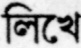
লিখে
